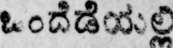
ಒಂದೆಡೆಯಲ್ಲಿ
